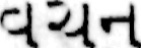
વચન
